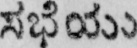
ಸಭೆಯು
